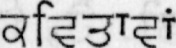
ਕਵਿਤਾਵਾਂ
